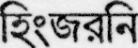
হিংজরনি
